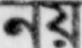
নয়
